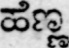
ಹೆಣ್ಣ
